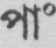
পা
